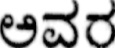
ಅವರ
